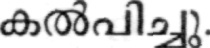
കല്‍പിച്ചു.
